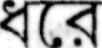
ধরে
